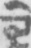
ਦੇ
